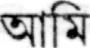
আমি
